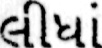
લીધાં
